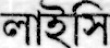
লাইসি
